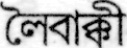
লৈবাক্কী
